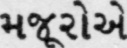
મજૂરોએ
